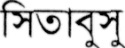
সিতাবুসু
